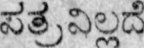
ಪತ್ರವಿಲ್ಲದೆ
